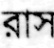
রাস
